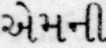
એમની
